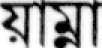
য়াম্না
